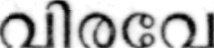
വിരവേ
